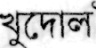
খুদোল
